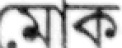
মোক
